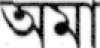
অমা
